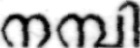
നമ്പി
